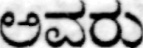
ಅವರು
